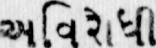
અવિરોધી
